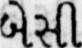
બેસી
